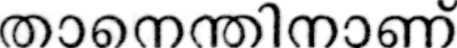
താനെന്തിനാണ്
